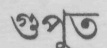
গুপুত
